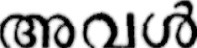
അവള്‍
